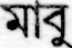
মাবু
